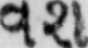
વશ
